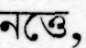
নত্তে,
